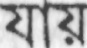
যায়
